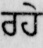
ਰਹੇ
